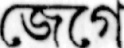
জেগে
